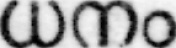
ധനം
